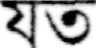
যত
